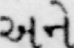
અને
